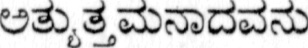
ಅತ್ಯುತ್ತಮನಾದವನು
